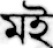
মই
